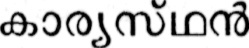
കാര്യസ്ഥന്‍
